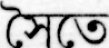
সৈতে
